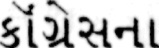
કૉંગ્રેસના
